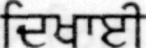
ਦਿਖਾਈ
